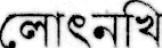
লোৎনখি
